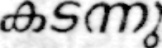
കടന്നു
